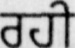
ਰਹੀ
